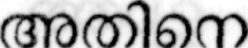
അതിനെ
